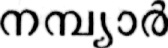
നമ്പ്യാര്‍
